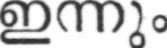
ഇന്നും
